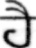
ਹੈ
